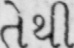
તેથી
